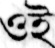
ওই
